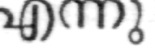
എന്നു
